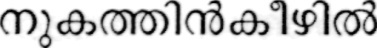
നുകത്തിന്‍കീഴില്‍
